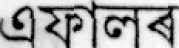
এফালৰ
